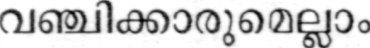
വഞ്ചിക്കാരുമെല്ലാം
